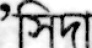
’সিদা
